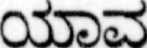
ಯಾವ
